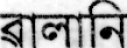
ৱালানি
